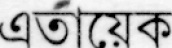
এতায়েক
